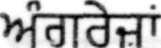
ਅੰਗਰੇਜ਼ਾਂ
